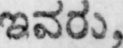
ಇವರು,
